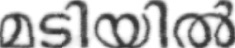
മടിയില്‍
